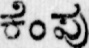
ಕೆಂಪು
